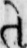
તે
